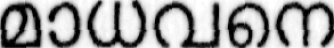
മാധവനെ
